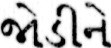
જોડીને
